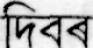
দিবৰ
